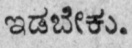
ಇಡಬೇಕು.
